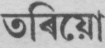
তৰিয়ো
